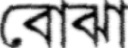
বোঝা
